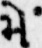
મેં
